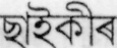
ছাইকীৰ
